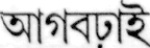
আগবঢ়াই
